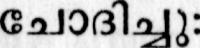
ചോദിച്ചു:
